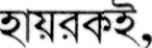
হায়রকই,
